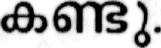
കണ്ടു.
